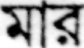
মার
